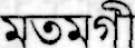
মতমগী
